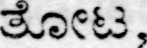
ತೋಟ,
